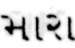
મારા
